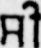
ਸੀ
